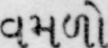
વમળો
